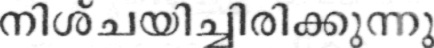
നിശ്ചയിച്ചിരിക്കുന്നു
